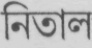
নিতাল
